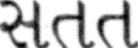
સતત
